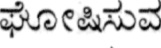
ಘೋಷಿಸುವ
